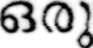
ഒരു
